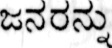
ಜನರನ್ನು
